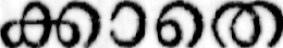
ക്കാതെ
